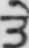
ਤੇ
